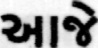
આજે
